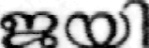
ജയി
